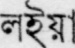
লইয়া
